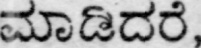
ಮಾಡಿದರೆ,
